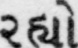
રહ્યો
